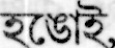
হঙোই,
